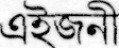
এইজনী
